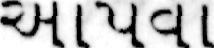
આપવા
